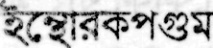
ইন্থোরকপগুম
